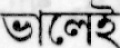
ভালেই
